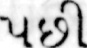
પછી
